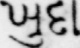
ખૂદા
